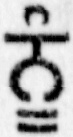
ਨੂੰ
